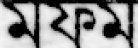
মফম
